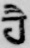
ਹੈ
